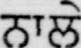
ਨਾਲੇ
